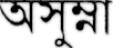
অসুম্না
